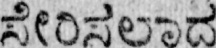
ಸೇರಿಸಲಾದ
